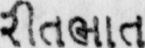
રીતભાત
